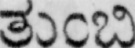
ತುಂಬಿ
